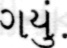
ગયું.
